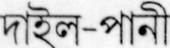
দাইল-পানী
